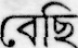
বেছি
